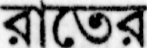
রাতের
